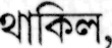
থাকিল,
